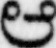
ಆ
